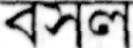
বসল
